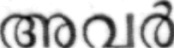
അവര്‍
